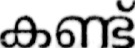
കണ്ട്
